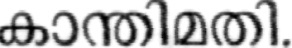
കാന്തിമതി.
